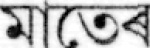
মাতেৰ
